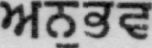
ਅਨੁਭਵ
